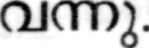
വന്നു.
